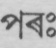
পৰঃ
